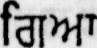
ਗਿਆ
